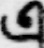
এ
